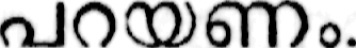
പറയണം.
